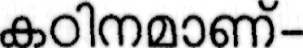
കഠിനമാണ്-
